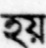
হয়
